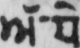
ਅੱਧੇ
